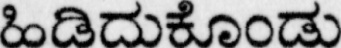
ಹಿಡಿದುಕೊಂಡು
